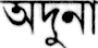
অদুনা
